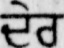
ਦੇਰ
